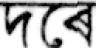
দৰে
